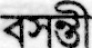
বসন্তী
